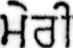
ਮੇਰੀ
